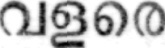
വളരെ
